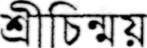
শ্রীচিন্ময়
